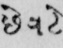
છેવટે
